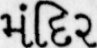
મંદિર
